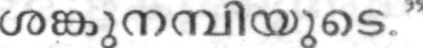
ശങ്കുനമ്പിയുടെ."
